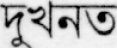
দুখনত
